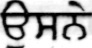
ਉਸਨੇ
